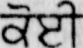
ਕੋਈ
